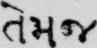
તેમજ
